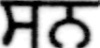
ਸਨ
